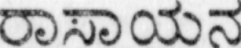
ರಾಸಾಯನ
